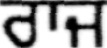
ਰਾਜ
